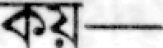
কয়-
